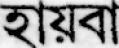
হায়বা
